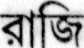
রাজি
